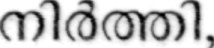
നിര്‍ത്തി,
